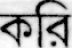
করি
